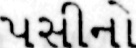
પસીનો
